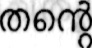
തന്റെ
